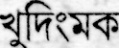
খুদিংমক
